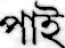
পাই
